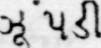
ઝુંપડી
